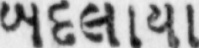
બદલાયા
